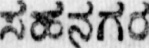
ಸಹನಗರ
